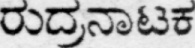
ರುದ್ರನಾಟಕ
